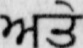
ਅਤੇ
